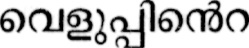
വെളുപ്പിന്റെ
